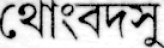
থোংবদসু
